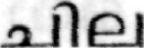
ചില
